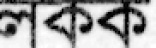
লকক
